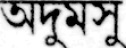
অদুমসু
